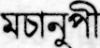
মচানুপী
